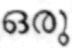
ഒരു
